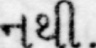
નથી.
